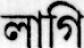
লাগি
